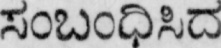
ಸಂಬಂಧಿಸಿದ
